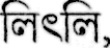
লিৎলি,
